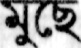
মুছে
